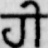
ਹੀ
